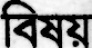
বিষয়
